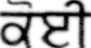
ਕੋਈ
